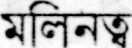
মলিনত্ব
